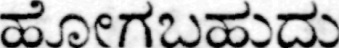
ಹೋಗಬಹುದು
